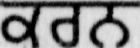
ਕਰਨ
